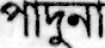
পাদুনা
